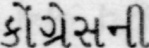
કોંગ્રેસની
